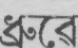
ধ্ৰুৱে
